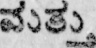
ಮತ್ತು
